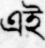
এই
